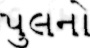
પુલનો
